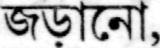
জড়ানো,
